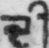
ਦੀ
